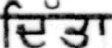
ਦਿੱਤਾ
